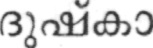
ദുഷ്കാ
